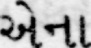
એના
